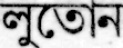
লুতোন
